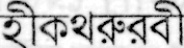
হীকথরুরবী
